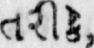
તરીકે,
